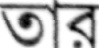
তার
